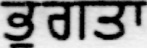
ਭੁਗਤਾ
